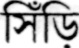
সিঁড়ি
